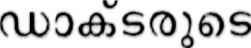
ഡാക്ടരുടെ
